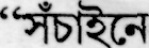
"সঁচাইনে
